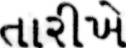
તારીખે
